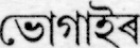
ভোগাইৰ
